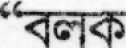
"বলক
